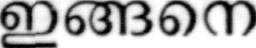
ഇങ്ങനെ
